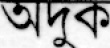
অদুক
